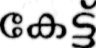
കേട്ട്
